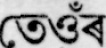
তেওঁৰ
